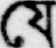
যে
